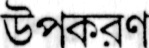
উপকরণ
